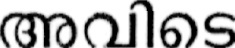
അവിടെ
